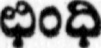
ಛಿಂಧಿ
